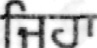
ਜਿਹਾ
